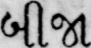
બીજા
